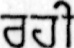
ਰਹੀ
